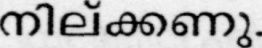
നില്ക്കണു.
